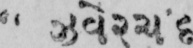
“ઝવેરચંદ
